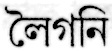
লৈগনি
